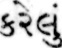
કરેલું
